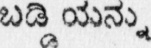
ಬಡ್ಡಿಯನ್ನು
